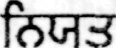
ਨਿਯਤ
